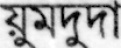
য়ুমদুদা
